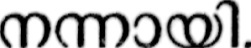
നന്നായി.
